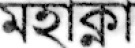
মহাক্না
